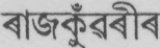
ৰাজকুঁৱৰীৰ
